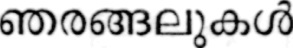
ഞരങ്ങലുകള്‍
